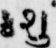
કશું
